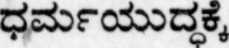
ಧರ್ಮಯುದ್ಧಕ್ಕೆ
